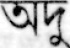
অদু
